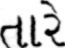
તારે
